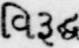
વિરૂદ્ધ
